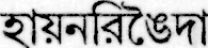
হায়নরিঙৈদা
